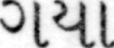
ગયા
